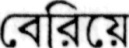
বেরিয়ে
